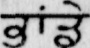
ਭਾਂਡੇ
